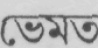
ভেমত
